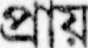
প্রায়
